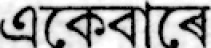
একেবাৰে
